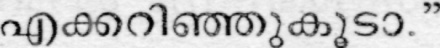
എക്കറിഞ്ഞുകൂടാ."
